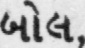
બોલ,
